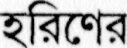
হরিণের
